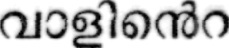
വാളിന്റെ
